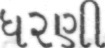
ધરણી
